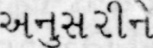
અનુસરીને
